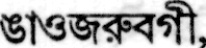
ঙাওজরুবগী,
